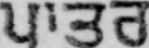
ਪਾਤਰ
